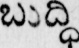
ಬುದ್ಧಿ
